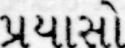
પ્રયાસો
